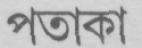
পতাকা
